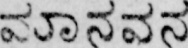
ಮಾನವನ
